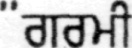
''ਗਰਮੀ
